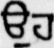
ਉਹ
